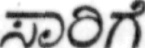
ಸಾರಿಗೆ
